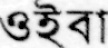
ওইবা
